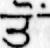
ਤੋਂ
